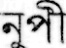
নুপী
